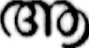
ആ
